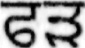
ਫੜ
